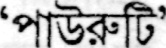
‘পাউরুটি’
